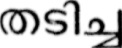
തടിച്ച
